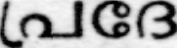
പ്രദേ
